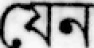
যেন
